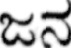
ಜನ
